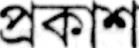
প্রকাশ
